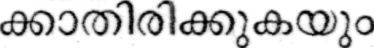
ക്കാതിരിക്കുകയും
